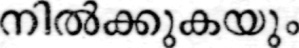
നില്‍ക്കുകയും
